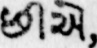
છીએ,
